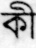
কী
